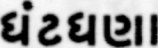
ધંટધણા
